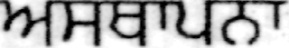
ਅਸਥਾਪਨਾ
